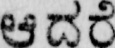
ಆದರೆ
